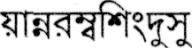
য়ান্নরম্বশিংদুসু
